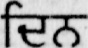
ਦਿਨ
